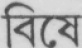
বিষে
